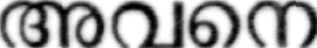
അവനെ
